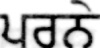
ਪਰਨੇ
